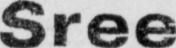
Sree
